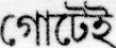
গোটেই
